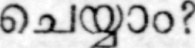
ചെയ്യാം?
